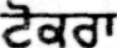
ਟੋਕਰਾ
